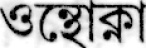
ওন্থোক্না
